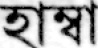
হাম্বা
